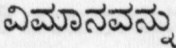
ವಿಮಾನವನ್ನು
